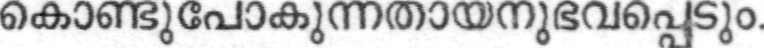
കൊണ്ടുപോകുന്നതായനുഭവപ്പെടും.
